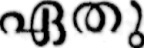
ഏതു
